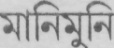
মানিমুনি
